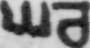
ਘਰ
